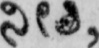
ನೀತಿ,
